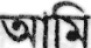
আমি
